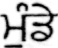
ਮੁੰਡੇ
